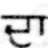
ਦਾ
